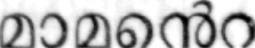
മാമന്റെ
